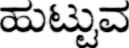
ಹುಟ್ಟುವ
